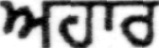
ਅਹਾਰ
